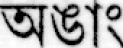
অঙাং
